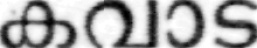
കവാട
